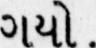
ગયો.
